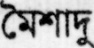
মৈশাদু
